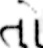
તો
